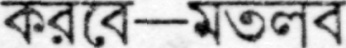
করবে—মতলব
